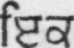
ਇਕ
